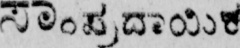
ಸಾಂಪ್ರದಾಯಿಕ
